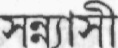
সন্ন্যাসী
